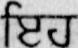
ਇਹ
